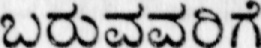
ಬರುವವರಿಗೆ
